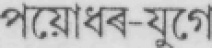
পয়োধৰ-যুগে
